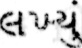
લખ્યું
